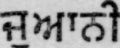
ਜੁਆਨੀ
